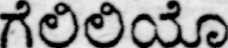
ಗೆಲಿಲಿಯೊ
